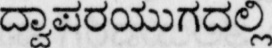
ದ್ವಾಪರಯುಗದಲ್ಲಿ
